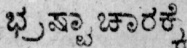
ಭ್ರಷ್ಟಾಚಾರಕ್ಕೆ
